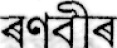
ৰণবীৰ
